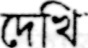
দেখি
